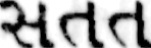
સતત
